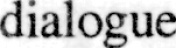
dialogue
